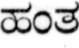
ಹಂತ
